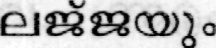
ലജ്ജയും
